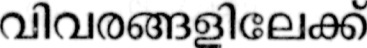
വിവരങ്ങളിലേക്ക്
